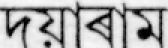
দয়াৰাম
